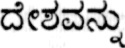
ದೇಶವನ್ನು
